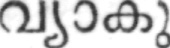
വ്യാകു
